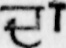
ਦਾ
